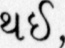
થઈ,
